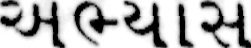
અભ્યાસ
